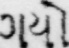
ગયો
